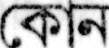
কোন
